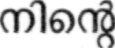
നിന്റെ
